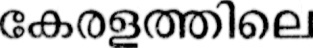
കേരളത്തിലെ
